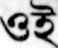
ওই
